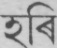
হৰি
